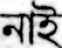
নাই
